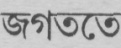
জগততে
